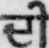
ਦੀ
